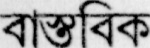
বাস্তবিক
